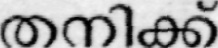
തനിക്ക്
